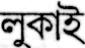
লুকাই
